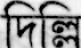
দিল্লি
